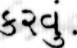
કરવું.
